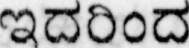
ಇದರಿಂದ
